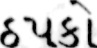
ઠપકો
